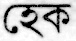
হেক
